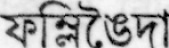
ফম্লিঙৈদা
